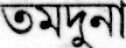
তমদুনা
